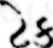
ટેક
